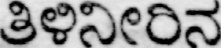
ತಿಳಿನೀರಿನ
